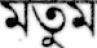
মতুম
